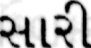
સારી
